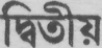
দ্বিতীয়
